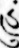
હું
